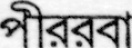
পীররবা
